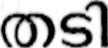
തടി
